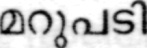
മറുപടി
